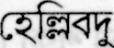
হেল্লিবদু
